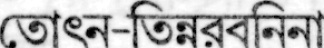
তোৎন-তিন্নরবনিনা
